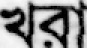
খরা
